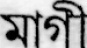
মাগী
